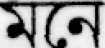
মনে
